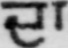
ਦਾ
